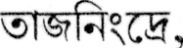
তাজনিংদ্রে,
